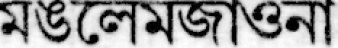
মঙলেমজাওনা
